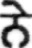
ਨੇ
